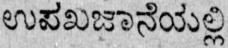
ಉಪಖಜಾನೆಯಲ್ಲಿ
